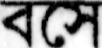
বসে
